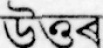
উত্তৰ
